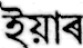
ইয়াৰ
